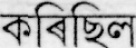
কৰিছিল
